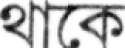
থাকে
